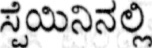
ಸ್ಪೆಯಿನಿನಲ್ಲಿ
